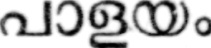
പാളയം
